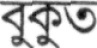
বুকুত
